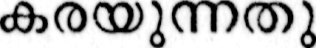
കരയുന്നതു
